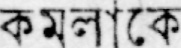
কমলাকে
